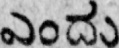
ಎಂದು
